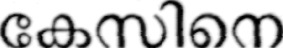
കേസിനെ
